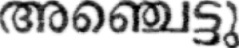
അഞ്ചെട്ടു
